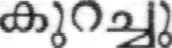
കുറച്ചു
